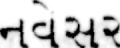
નવેસર
